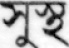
সুস্থ
